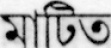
মাটিত
